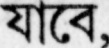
যাবে,
